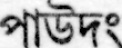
পাউদং
